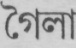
গৈলা
